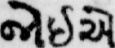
જોઈએ
